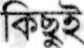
কিছুই
